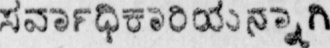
ಸರ್ವಾಧಿಕಾರಿಯನ್ನಾಗಿ
